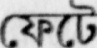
ফেটে
